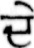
ਦੇ
